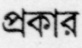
প্রকার
